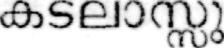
കടലാസ്സു
